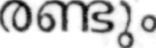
രണ്ടും
